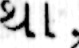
થા,
